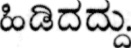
ಹಿಡಿದದ್ದು.
